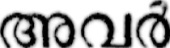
അവര്‍
